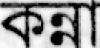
কন্না
